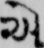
એ
